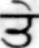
ਤੇ
